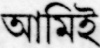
আমিই
